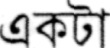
একটা
